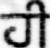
ਹੀ
